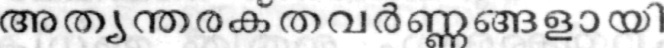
അത്യന്തരക്തവര്‍ണ്ണങ്ങളായി
